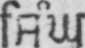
ਸਿੰਘ
